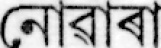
নোৱাৰা
